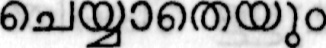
ചെയ്യാതെയും
